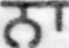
ਨਾ
